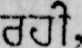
ਰਹੀ,
